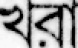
খরা
